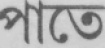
পাতে
